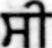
ਸੀ
